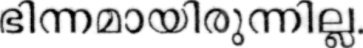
ഭിന്നമായിരുന്നില്ല.
